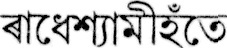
ৰাধেশ্যামীহঁতে
